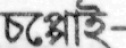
চপ্পোই-
